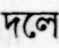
দলে
